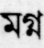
মগ্ন
